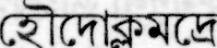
হৌদোক্লমদ্রে
